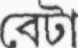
বেটা
